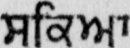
ਸਕਿਆ
